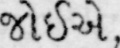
જોઈએ,
